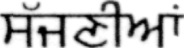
ਸੱਜਣੀਆਂ
